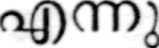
എന്നു
